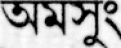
অমসুং
